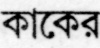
কাকের
